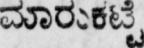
ಮಾರುಕಟ್ಟೆ
